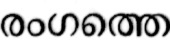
രംഗത്തെ
